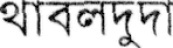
থাবলদুদা
